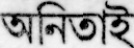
অনিতাই
